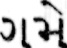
ગમે
